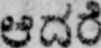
ಆದರೆ
